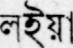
লইয়া
